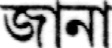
জানা
